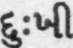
દુઃખી
